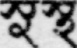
সুস্থ
